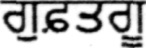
ਗੁਫ਼ਤਗੂ
